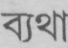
ব্যথা
